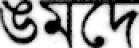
ঙমদে
